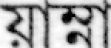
য়াম্না
